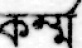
কর্ম্ম
